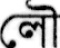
লৌ
